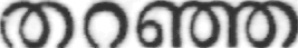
തറഞ്ഞ
